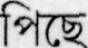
পিছে
